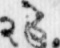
રહે.
